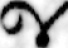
જ
